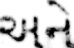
અને
